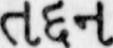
તદ્દન
